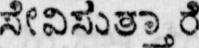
ಸೇವಿಸುತ್ತಾರೆ
